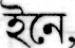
ইনে,
